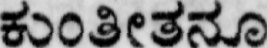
ಕುಂತೀತನೂ
